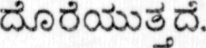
ದೊರೆಯುತ್ತದೆ.
